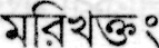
মরিখক্তং
